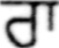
ਰਾ
